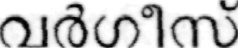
വര്‍ഗീസ്
